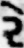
રે
